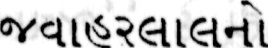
જવાહરલાલનો
